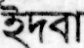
ইদবা
